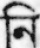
নি
